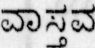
ವಾಸ್ತವ
